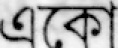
একো
